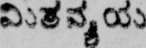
ಮಿತವ್ಯಯ
